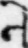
ને
